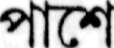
পাশে
